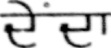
ਦੇਂਦਾ
